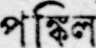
পঙ্কিল
